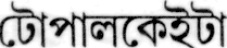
টোপালকেইটা
